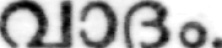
വാദം.
